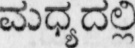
ಮಧ್ಯದಲ್ಲಿ
